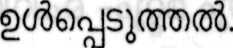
ഉള്‍പ്പെടുത്തല്‍.
